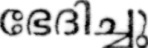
ഭേദിച്ചു
